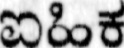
ಐಹಿಕ
